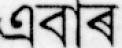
এবাৰ
